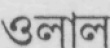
ওলাল
